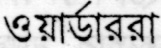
ওয়ার্ডাররা
